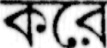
করে
